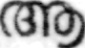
ആ
